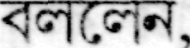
বললেন,
